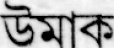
উমাক
